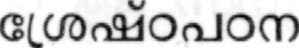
ശ്രേഷ്ഠപഠന
